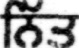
ਨਿੱਤ
